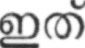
ഇത്
